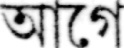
আগে
